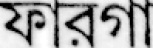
ফারগা
